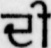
ਦੀ
